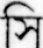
সি
